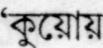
‘কুয়োয়
